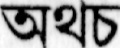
অথচ
